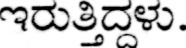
ಇರುತ್ತಿದ್ದಳು.
